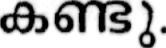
കണ്ടു.
